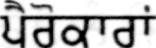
ਪੈਰੋਕਾਰਾਂ
